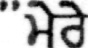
''ਮੇਰੇ
